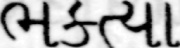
ભક્ત્યા
